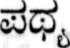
ಪಥ್ಯ
